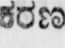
ಕರಣ
